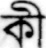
কী
